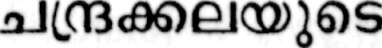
ചന്ദ്രക്കലയുടെ
